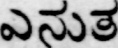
ಎನುತ
